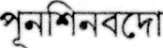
পূনশিনবদো
